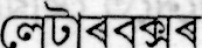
লেটাৰবক্সৰ
